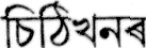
চিঠিখনৰ
